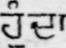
ਹੁੰਦਾ
